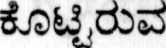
ಕೊಟ್ಟಿರುವ
